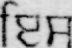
ਇਸ
